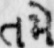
તમે
